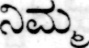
ನಿಮ್ಮ
